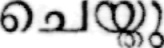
ചെയ്തു
